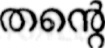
തന്റെ
